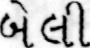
બેલી
